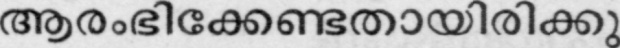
ആരംഭിക്കേണ്ടതായിരിക്കു
